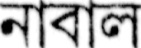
নাবাল
